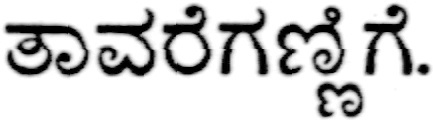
ತಾವರೆಗಣ್ಣಿಗೆ.
